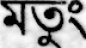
মতুং
